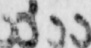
ಮು
